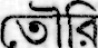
তৌরি
